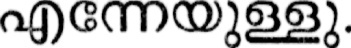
എന്നേയുള്ളു.
